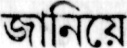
জানিয়ে
